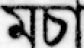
মচা
